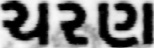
ચરણ
